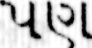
પણ
